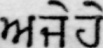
ਅਜੇਹੇ
